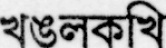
খঙলকখি
